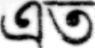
এত
